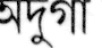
অদুগা
